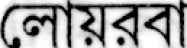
লোয়রবা
